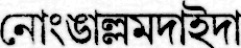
নোংঙাল্লমদাইদা
